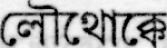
লৌথোক্কে
